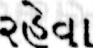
રહેવા
